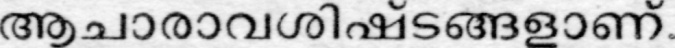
ആചാരാവശിഷ്ടങ്ങളാണ്.
